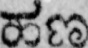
ಹಣ
